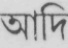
আদি
